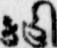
કહી
